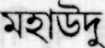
মহাউদু
